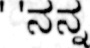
‘ನನ್ನ
